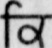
ਕਿ
